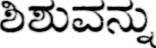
ಶಿಶುವನ್ನು
